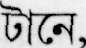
টানে,
